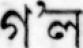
গ'ল
